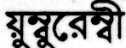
য়ুম্বুরেম্বী
